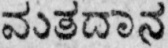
ಮತದಾನ
